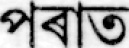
পৰাত
